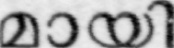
മായി
